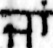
ਜਾਂ
